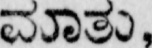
ಮಾತು,
